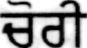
ਚੋਰੀ
